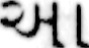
આ
